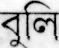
বুলি
